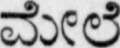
ಮೇಲೆ
